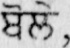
ਬੋਲੇ,
